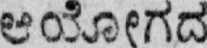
ಆಯೋಗದ
